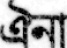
ঐনা
